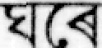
ঘৰে
